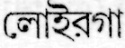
লোইরগা
